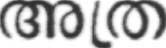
അത്ര
